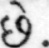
છે.
